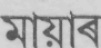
মায়াৰ
